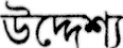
উদ্দেশ্য
